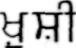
ਖ਼ੁਸ਼ੀ
